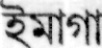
ইমাগা
